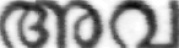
അവ
